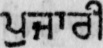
ਪੁਜਾਰੀ
